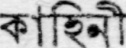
কাহিনী
